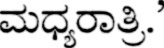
ಮಧ್ಯರಾತ್ರಿ.'
